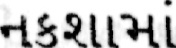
નકશામાં
